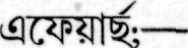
এফেয়ার্ছ;-
